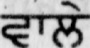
ਵਾਲੇ
